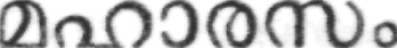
മഹാരസം
